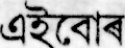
এইবোৰ
